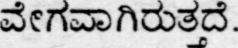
ವೇಗವಾಗಿರುತ್ತದೆ.
